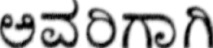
ಅವರಿಗಾಗಿ
